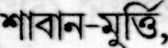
শাবান-মুর্ত্তি,
